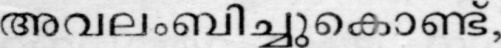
അവലംബിച്ചുകൊണ്ട്,
